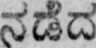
ನಡೆದ
